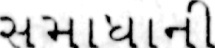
સમાધાની
